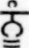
ਨੂੰ
